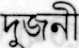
দুজনী
